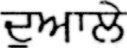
ਦੁਆਲੇ
